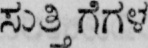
ಸುತ್ತಿಗೆಗಳ
